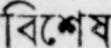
বিশেষ
